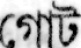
গোট
